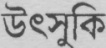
উৎসুকি
